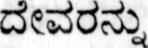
ದೇವರನ್ನು
